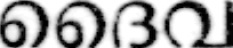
ദൈവ
